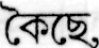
কৈছে,
